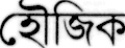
হৌজিক
